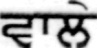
ਵਾਲੇ
